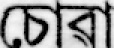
চোৱা
